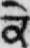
ਕੇ
